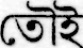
তৌই
